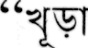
“খূড়া
